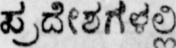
ಪ್ರದೇಶಗಳಲ್ಲಿ
